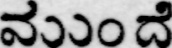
ಮುಂದೆ
